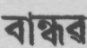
বান্ধৱ
